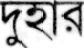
দুহার
